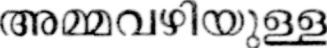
അമ്മവഴിയുള്ള
